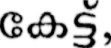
കേട്ട്,
